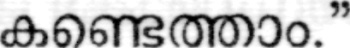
കണ്ടെത്താം.”
